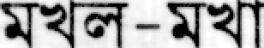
মখল-মখা
